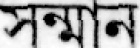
সন্মান
